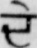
ਦੇ
